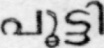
പൂട്ടി
